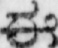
ಈ
